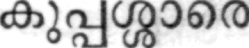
കുപ്പശ്ശാരെ
